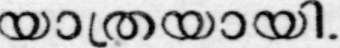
യാത്രയായി.
